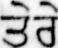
ਤੇਰੇ
